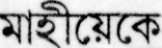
মাহীয়েকে
